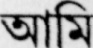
আমি
